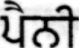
ਪੈਨੀ
